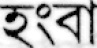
হংবা
